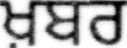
ਖ਼ਬਰ
